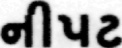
નીપટ
